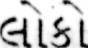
લોકો
